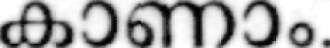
കാണാം.
